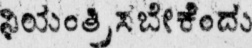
ನಿಯಂತ್ರಿಸಬೇಕೆಂದು
